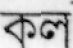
কল
